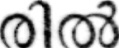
രില്‍
